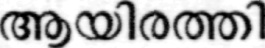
ആയിരത്തി
